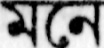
মনে
